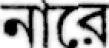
নারে
